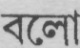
বলো
